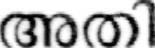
അതി
